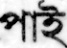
পাই
